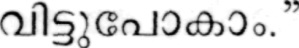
വിട്ടുപോകാം."
